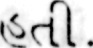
હતી.
